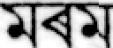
মৰম
